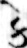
કે
